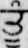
ਤੂੰ
